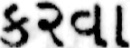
કરવા
